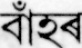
বাঁহৰ
